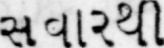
સવારથી
